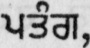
ਪਤੰਗ,
